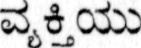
ವ್ಯಕ್ತಿಯು
